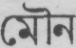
মৌন
